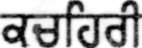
ਕਚਹਿਰੀ
